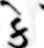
કે
